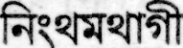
নিংথমথাগী
